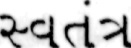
સ્વતંત્ર
